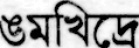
ঙমখিদ্রে
